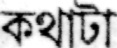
কথাটা
